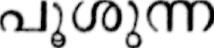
പൂശുന്ന
